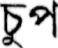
চুপ
